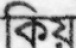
কিয়
